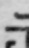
ਹੋ
